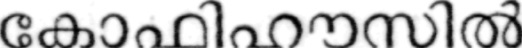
കോഫിഹൌസില്‍
